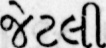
જેટલી
